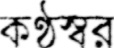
কণ্ঠস্বর
